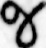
જ
